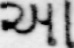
આ
